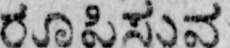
ರೂಪಿಸುವ
